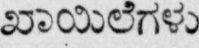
ಖಾಯಿಲೆಗಳು
